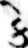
કે
